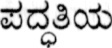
ಪದ್ಧತಿಯ
